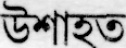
উশাহত
